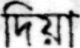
দিয়া
